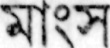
মাংস
